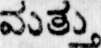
ಮತ್ತು
